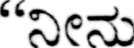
"ನೀನು
